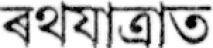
ৰথযাত্রাত
